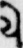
યે
